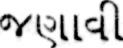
જણાવી
